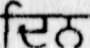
ਦਿਨ
